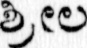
ಶ್ರೀಲ
